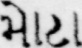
મોટા
